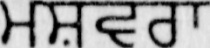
ਮਸ਼ਵਰਾ
